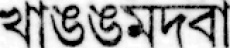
খাঙঙমদবা
